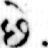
છે.
